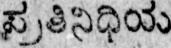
ಪ್ರತಿನಿಧಿಯ
